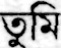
তুমি
